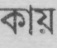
কায়
